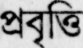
প্রবৃত্তি
